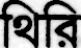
থিরি
